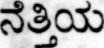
ನೆತ್ತಿಯ
